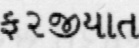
ફરજીયાત
